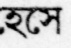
হেসে
